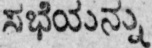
ಸಭೆಯನ್ನು
